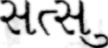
સત્સુ
